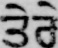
ਤੇਰੇ
